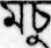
মচু
